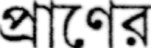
প্রাণের
